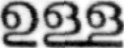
ഉള്ള
